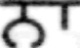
ਨਾ
